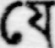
যে
